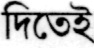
দিতেই
